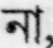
না,
